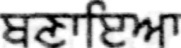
ਬਣਾਇਆ
